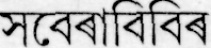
সবেৰাবিবিৰ
